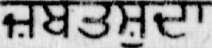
ਜ਼ਬਤਸ਼ੁਦਾ
